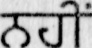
ਨਹੀਂ
